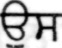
ਉਸ
